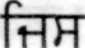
ਜਿਸ
